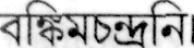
বঙ্কিমচন্দ্রনি।
